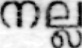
നല്ല
